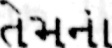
તેમના
